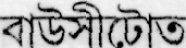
বাউসীটোত
